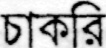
চাকরি
